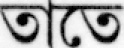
তাতে
